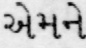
એમને
